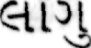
લાગુ
